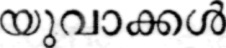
യുവാക്കള്‍
